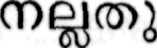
നല്ലതു
